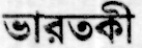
ভারতকী
